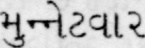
મુન્નેટવાર
